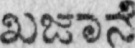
ಖಜಾನೆ
